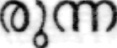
രുന്ന
